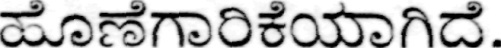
ಹೊಣೆಗಾರಿಕೆಯಾಗಿದೆ.
